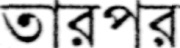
তারপর
